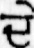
ਦੇ
